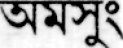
অমসুং
